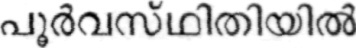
പൂര്‍വസ്ഥിതിയില്‍
